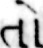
તો
